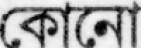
কোনো
